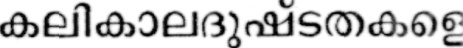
കലികാലദുഷ്ടതകളെ
